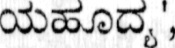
ಯಹೂದ್ಯ’,
